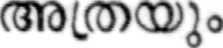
അത്രയും
